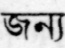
জন্য
